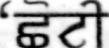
'ਛੋਟੀ
